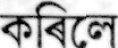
কৰিলে
